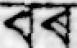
বৰ
